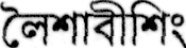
লৈশাবীশিং
